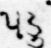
પડું
